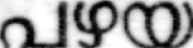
പഴയ
